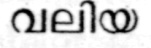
വലിയ
